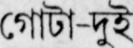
গোটা-দুই
